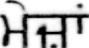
ਮੇਜ਼ਾਂ
